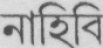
নাহিবি
